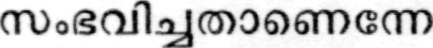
സംഭവിച്ചതാണെന്നേ
